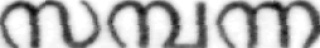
സമ്പന്ന
